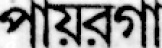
পায়রগা
